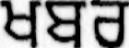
ਖਬਰ
